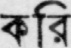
করি
